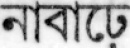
নাবাঢ়ে
